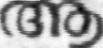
ആ
